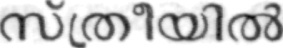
സ്ത്രീയില്‍
